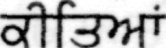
ਕੀਤਿਆਂ
